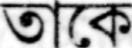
তাকে
